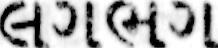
લગભગ
